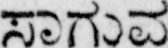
ಸಾಗುವ
